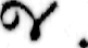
જ.
